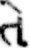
તે
